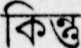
কিন্তু
